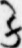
કે
